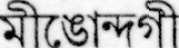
মীঙোন্দগী
